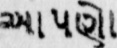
આપણો
